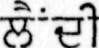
ਲੈਂਦੀ
